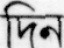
দিন
